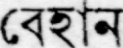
বেহান
